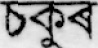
চকুৰ
